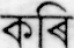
কৰি
